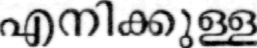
എനിക്കുള്ള
